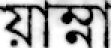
য়াম্না
